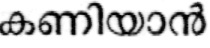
കണിയാന്‍
